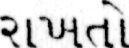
રાખતો
